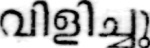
വിളിച്ചു
